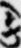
કે
